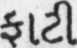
ફાટી
